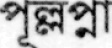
পূল্লপ্না
